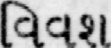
વિવશ
